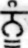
ਨੂੰ
